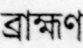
ব্রাহ্মণ
